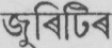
জুৰিটিৰ
